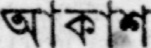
আকাশ
